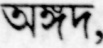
অঙ্গদ,
